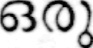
ഒരു
